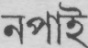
নপাই
